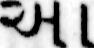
આ
